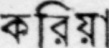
করিয়া
